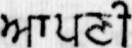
ਆਪਣੀ
